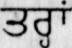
ਤਰ੍ਹਾਂ
